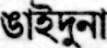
ঙাইদুনা
